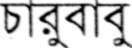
চারুবাবু
